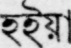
হইয়া
